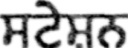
ਸਟੇਸ਼ਨ
